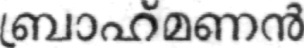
ബ്രാഹ്മണന്‍
